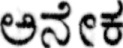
ಅನೇಕ
